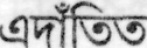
এদাঁতিত
